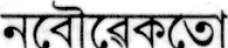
নবৌৱেকতো
